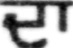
ਦਾ
